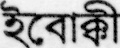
ইবোক্কী
